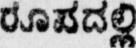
ರೂಪದಲ್ಲಿ
